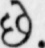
છે.
